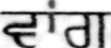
ਵਾਂਗ
